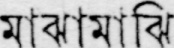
মাঝামাঝি
